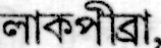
লাকপীব্রা,
